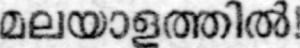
മലയാളത്തില്‍!
